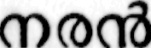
നരന്‍
